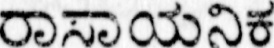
ರಾಸಾಯನಿಕ
